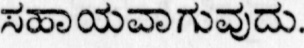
ಸಹಾಯವಾಗುವುದು.
